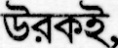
উরকই,
